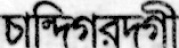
চান্দিগরদগী
